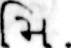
મિ.
